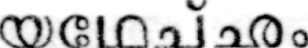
യഥേച്ഛം
